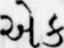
એક
